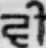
ਵੀ
